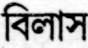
বিলাস
